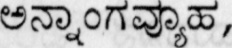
ಅನ್ನಾಂಗವ್ಯೂಹ,
